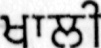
ਖਾਲੀ
